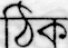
ঠিক
